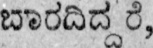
ಬಾರದಿದ್ದರೆ,
